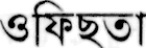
ওফিছতা
